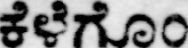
ಕೆಳೆಗೊಂ
